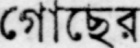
গোছের
